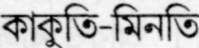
কাকুতি-মিনতি
